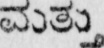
ಮತ್ತು
